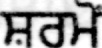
ਸ਼ਰਮੋਂ
